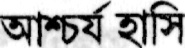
হাসি
